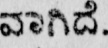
ವಾಗಿದೆ.
